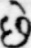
છે
